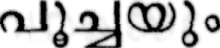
പൂച്ചയും
